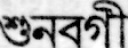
শুনবগী
